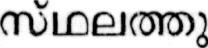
സ്ഥലത്തു
